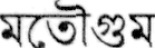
মতৌগুম
